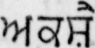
ਅਕਸ਼ੈ
